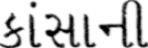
કાંસાની
